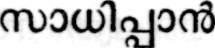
സാധിപ്പാന്‍
